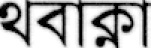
থবাক্না
